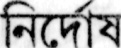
নির্দোষ
